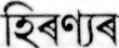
হিৰণ্যৰ
